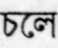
চলে
